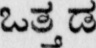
ಒತ್ತಡ
